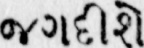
જગદીશે
